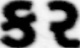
કર
